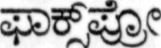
ಫಾಕ್ಸ್‌ಪ್ರೋ
